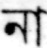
না
